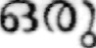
ഒരു
